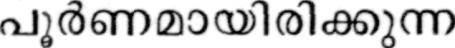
പൂര്‍ണമായിരിക്കുന്ന
